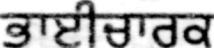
ਭਾਈਚਾਰਕ
